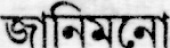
জানিমনো
